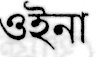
ওইনা
